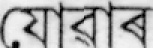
যোৱাৰ
